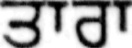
ਤਾਰਾ
